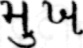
મુખ
